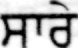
ਸਾਰੇ
